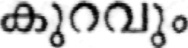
കുറവും
